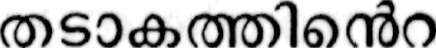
തടാകത്തിന്റെ
